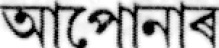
আপোনাৰ
